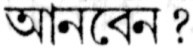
আনবেন?
